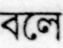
বলে
